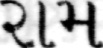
રામ
